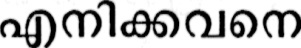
എനിക്കവനെ
